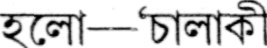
হলো–‘চালাকী
